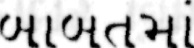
બાબતમાં
